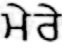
ਮੇਰੇ
